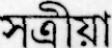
সত্রীয়া
